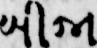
બીજા
